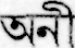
অনী
